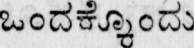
ಒಂದಕ್ಕೊಂದು
